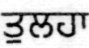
ਤੁਲਹਾ
